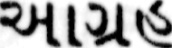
આગ્રહ
